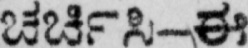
ಚರ್ಚಿಸಿ-ಈ
